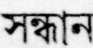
সন্ধান
